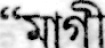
“মাগী
